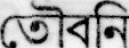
তৌবনি
